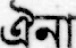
ঐনা
